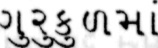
ગુરુકુળમાં
